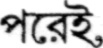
পরেই,
